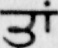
ਤਾਂ
